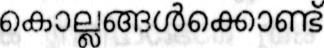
കൊല്ലങ്ങള്‍ക്കൊണ്ട്
